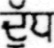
ਦੁੱਧ
